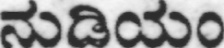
ನುಡಿಯಂ
